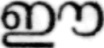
ഈ
